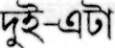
দুই-এটা
